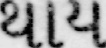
થાય
